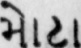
મોટા
